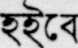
হইবে
